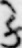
કે
